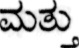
ಮತ್ತು
